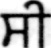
ਸੀ
